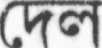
দেল
